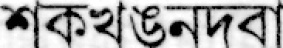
শকখঙনদবা
